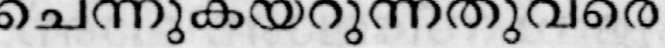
ചെന്നുകയറുന്നതുവരെ
